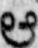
ಆ
